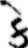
કે
